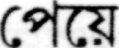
পেয়ে
